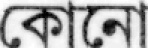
কোনো
